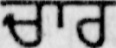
ਚਾਰ
